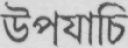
উপযাচি
